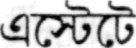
এস্টেটে
